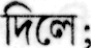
দিলে;
